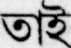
তাই
